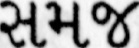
સમજ
